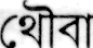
থৌবা
